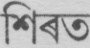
শিৰত
